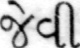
જેવી
